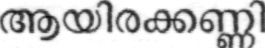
ആയിരക്കണ്ണി
